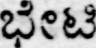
ಭೇಟಿ
